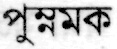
পুম্নমক
